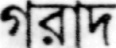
গরাদ
